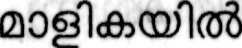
മാളികയില്‍
